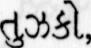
તુઝકો,
